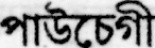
পাউচেগী
